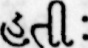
હતી:
